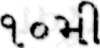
૧૦મી
